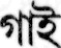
গাই
